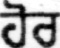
ਹੋਰ
